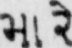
મારે
